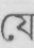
যে
